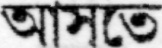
আসতে
